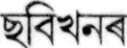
ছবিখনৰ
